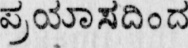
ಪ್ರಯಾಸದಿಂದ
